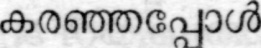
കരഞ്ഞപ്പോള്‍
